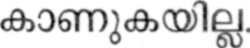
കാണുകയില്ല.
